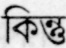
কিন্তু
